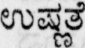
ಉಷ್ಣತೆ
